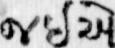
જઈએ
